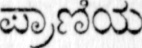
ಪ್ರಾಣಿಯ
